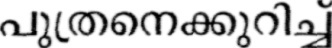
പുത്രനെക്കുറിച്ച്
